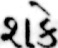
શકે
